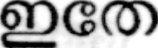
ഇതേ
